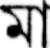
মা
